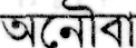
অনৌবা
